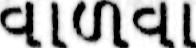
વાળવા
